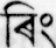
ৰিং
